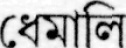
ধেমালি
